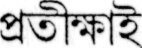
প্রতীক্ষাই
